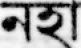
নহা
